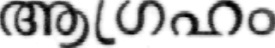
ആഗ്രഹം
